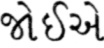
જોઈએ
